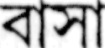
বাসা
